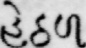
હેઠળ
